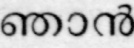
ഞാന്‍
